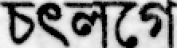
চৎলগে
